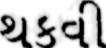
થકવી
